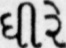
ધીરે
